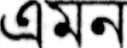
এমন
